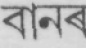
বানৰ
